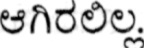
ಆಗಿರಲಿಲ್ಲ.
